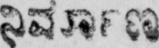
ನಿರ್ಮಾಣ
